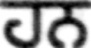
ਹਨ
